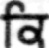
ਕਿ
